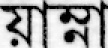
য়াম্না
